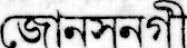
জোনসনগী
